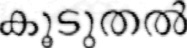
കൂടുതല്‍
